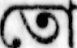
তো
